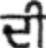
ਦੀ
